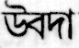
উবদা
